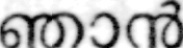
ഞാന്‍
